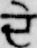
ਦੇ
